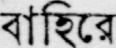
বাহিরে
